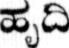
ಹೃದಿ
